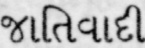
જાતિવાદી
